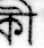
কী
